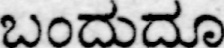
ಬಂದುದೂ
